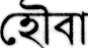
হৌবা
